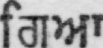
ਗਿਆ
